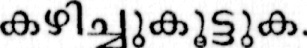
കഴിച്ചുകൂട്ടുക.
